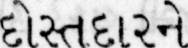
દોસ્તદારને
